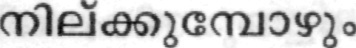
നില്ക്കുമ്പോഴും
